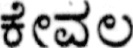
ಕೇವಲ
